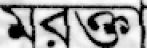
মরক্তা
